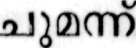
ചുമന്ന്
